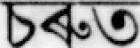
চৰুত
